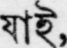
যাই,
